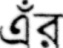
এঁর
